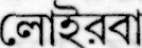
লোইরবা
